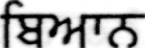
ਬਿਆਨ
